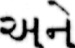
અને
